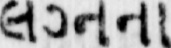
લગ્નના
